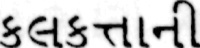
કલકત્તાની
